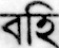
বহি
